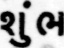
શુંભ
